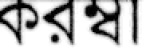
করম্বা
